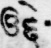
ઉદ્દે-
